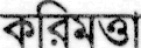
করিমত্তা
